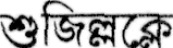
শুজিল্লক্লে
